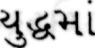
યુદ્ધમાં
